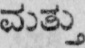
ಮತ್ತು
